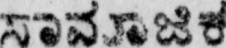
ಸಾಮಾಜಿಕ
